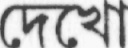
দেখো
